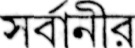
সর্বানীর
